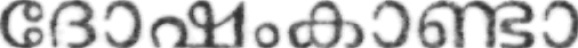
ദോഷംകാണ്ടാ
